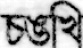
চঙখি
